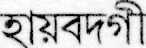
হায়বদগী
